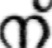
ന്
